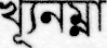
খ্যূনম্না
